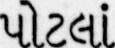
પોટલાં
